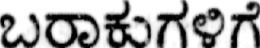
ಬರಾಕುಗಳಿಗೆ
